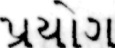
પ્રયોગ
